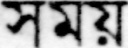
সময়
